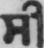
ਸੀ
